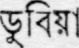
ডুবিয়া
